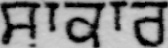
ਸਾਕਾਰ
